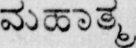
ಮಹಾತ್ಮ
